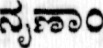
ನೃಣಾಂ
